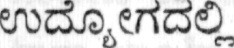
ಉದ್ಯೋಗದಲ್ಲಿ
